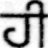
ਹੀ
